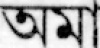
অমা
